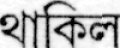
থাকিল
